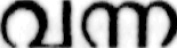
വന്ന
